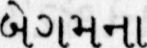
બેગમના
